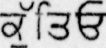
ਕੁੱਤਿਓ
